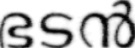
ഭടന്‍
